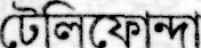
টেলিফোন্দা
